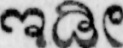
ಇಡೀ
